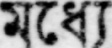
মধ্যে
